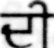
ਦੀ
